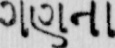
ગણના
